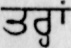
ਤਰ੍ਹਾਂ
